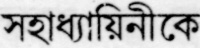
সহাধ্যায়িনীকে
